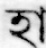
হা
